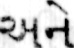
અને
